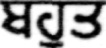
ਬਹੁਤ
